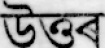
উত্তৰ
